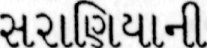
સરાણિયાની
